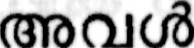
അവള്‍
